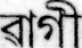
ৱাগী
